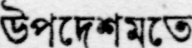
উপদেশমতে
